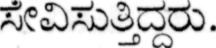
ಸೇವಿಸುತ್ತಿದ್ದರು.
